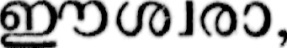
ഈശ്വരാ,
